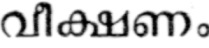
വീക്ഷണം
